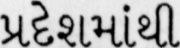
પ્રદેશમાંથી
